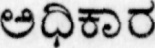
ಅಧಿಕಾರ
